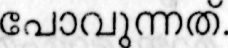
പോവുന്നത്.
